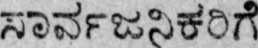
ಸಾರ್ವಜನಿಕರಿಗೆ
